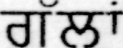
ਗੱਲਾਂ
